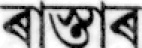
ৰাস্তাৰ
